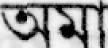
অমা
